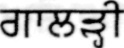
ਗਾਲੜ੍ਹੀ
